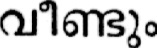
വീണ്ടും
